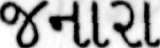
જનારા
